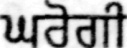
ਘਰੋਗੀ
